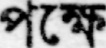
পক্ষে
